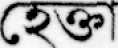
হেক্তা
